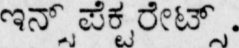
ಇನ್ಸ್‌ಪೆಕ್ಟರೇಟ್ಸ್.
